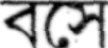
বসে
